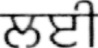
ਲਈ
